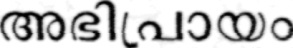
അഭിപ്രായം
